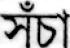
সঁচা
